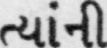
ત્યાંની
